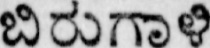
ಬಿರುಗಾಳಿ
